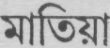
মাতিয়া
